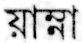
য়াম্না
